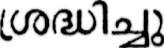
ശ്രദ്ധിച്ചു
